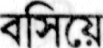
বসিয়ে
